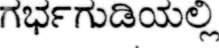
ಗರ್ಭಗುಡಿಯಲ್ಲಿ
